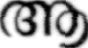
ആ
